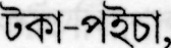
টকা-পইচা,
